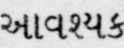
આવશ્યક
